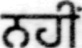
ਨਹੀ
